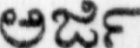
ಅರ್ಜಿ
